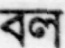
বল
